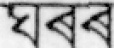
ঘৰৰ
